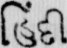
હિંદી
